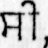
ਸੀ,
